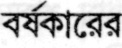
বর্ষকারের
